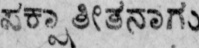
ಪಕ್ಷಾತೀತನಾಗು
